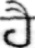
ਹੈ
